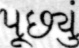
પૂછ્યું
